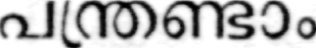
പന്ത്രണ്ടാം
